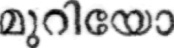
മുറിയോ
